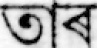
তাৰ
